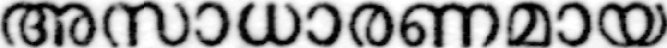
അസാധാരണമായ
